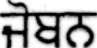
ਜੋਬਨ
